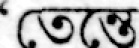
'তেন্তে
